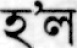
হ'ল
